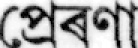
প্রেৰণা
